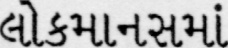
લોકસમાનમાં
